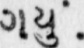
ગયું.
